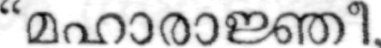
“മഹാരാജ്ഞീ,
